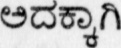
ಅದಕ್ಕಾಗಿ
